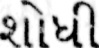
શોધી
